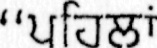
''ਪਹਿਲਾਂ
